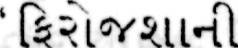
'કિરોજશાની
